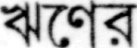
ঋণের
